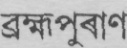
ব্ৰহ্মপুৰাণ
